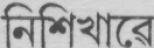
নিশিখাৱে
